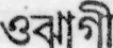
ওঝাগী
